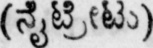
(ನೈಟ್ರೇಟು)
